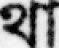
থা
